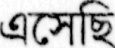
এসেছি
